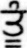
ਤੂੰ
